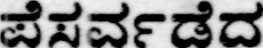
ಪೆಸರ್ವಡೆದ
